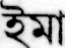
ইমা
